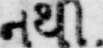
નથી.
